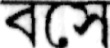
বসে
